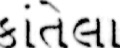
કાંતેલા
